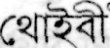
থোইবী
